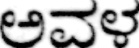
ಅವಳ
